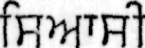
ਸਿਆਸੀ
